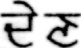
ਦੇਣ
